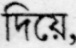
দিয়ে,
